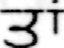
ਤਾਂ
